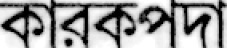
কারকপদা
